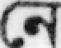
নে
